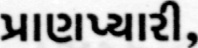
પ્રાણપ્યારી,
